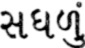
સધળું
